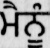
ਮੈਨੂੰ
